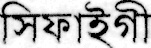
সিফাইগী
